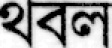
থবল
